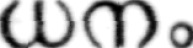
ധനം
